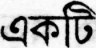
একটি
